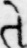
તે
